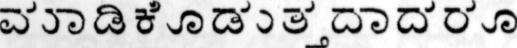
ಮಾಡಿಕೊಡುತ್ತದಾದರೂ
